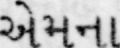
એમના
